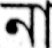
না
